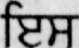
ਇਸ
